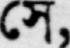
সে,
